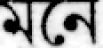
মনে
